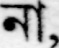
না,
